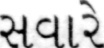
સવારે
